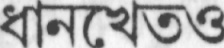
ধানখেতও
